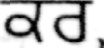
ਕਰ,
